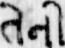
તેની
